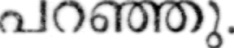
പറഞ്ഞു.
